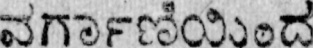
ವರ್ಗಾಣಿಯಿಂದ
